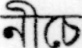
নীচে
